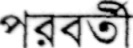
পরবর্তী
